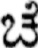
ಚೆ
